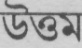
উত্তম
